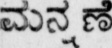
ಮನ್ನಣೆ
